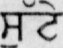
ਸੁੱਟੇ
